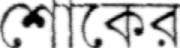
শোকের
